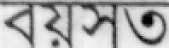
বয়সত
